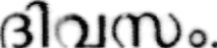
ദിവസം.
